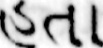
હતા
